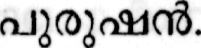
പുരുഷന്‍.
